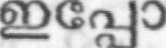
ഇപ്പോ
